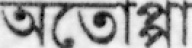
অতোপ্পা
